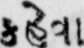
કહેવા
